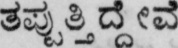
ತಪ್ಪುತ್ತಿದ್ದೇವೆ
